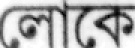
লোকে
